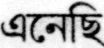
এনেছি
